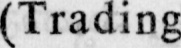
(Trading
